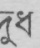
দুধ
